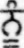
ਨੂੰ
